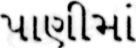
પાણીમાં
